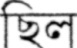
ছিল
